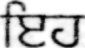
ਇਹ
